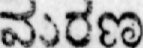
ಮರಣ
